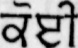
ਕੋਈ
